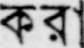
করা
